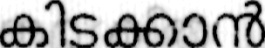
കിടക്കാന്‍
